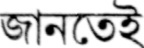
জানতেই
